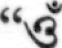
"ওঁ
